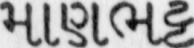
માણભટ્ટ-કવિ
